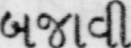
બજાવી
